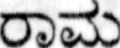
ರಾಮ
